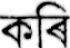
কৰি
